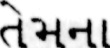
તેમના
